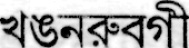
খঙনরুবগী
